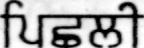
ਪਿਛਲੀ
